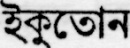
ইকুতোন
